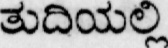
ತುದಿಯಲ್ಲಿ
